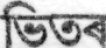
ভিতৰ
